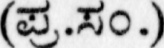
(ಪ್ರ.ಸಂ.)
